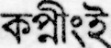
কপ্নীংই
